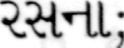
રસના;
